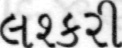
લશ્કરી
